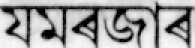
যমৰজাৰ
